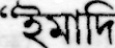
“ইমাদি
